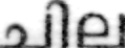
ചില
